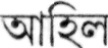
আহিল
